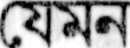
যেমন
